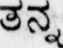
ತನ್ನ
